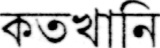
কতখানি
